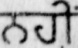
ਨਹੀਂ
